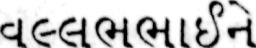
વલ્લભભાઈને
